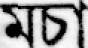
মচা
